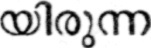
യിരുന്ന
